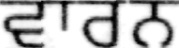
ਵਾਰਨ
